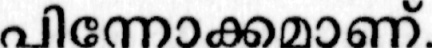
പിന്നോക്കമാണ്.
